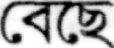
বেছে
